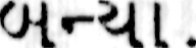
બન્યા.
